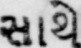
સાથે
